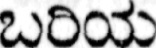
ಬರಿಯ
